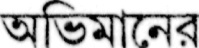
অভিমানের
